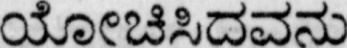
ಯೋಚಿಸಿದವನು
